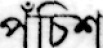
পঁচিশ
